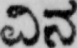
ವಿನ
